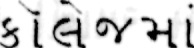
કૉલેજમાં
